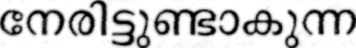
നേരിട്ടുണ്ടാകുന്ന
